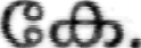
കേ.
